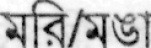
মরি/মঙা
